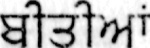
ਬੀਤੀਆਂ
